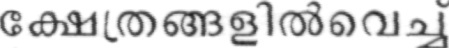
ക്ഷേത്രങ്ങളില്‍വെച്ച്
